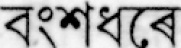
বংশধৰে
